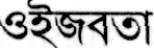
ওইজবতা
